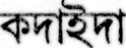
কদাইদা
